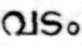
വടം
